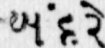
બંદરે
